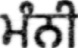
ਮੰਨੀ
